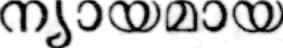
ന്യായമായ
